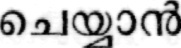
ചെയ്യാന്‍
